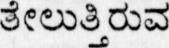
ತೇಲುತ್ತಿರುವ
